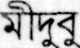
মীদুবু
